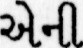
એની
